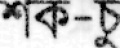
শক-চু
